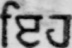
ਇਹ
